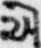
એ
